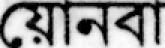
য়োনবা
